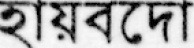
হায়বদো
